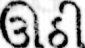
ઊઠી
